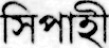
সিপাহী
